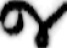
જ
